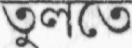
তুলতে
